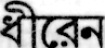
ধীরেন
